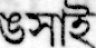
ঙসাই
